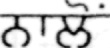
ਨਾਲੋਂ
